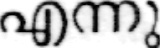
എന്നു
